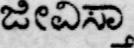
ಜೀವಿಸ್ತಾ
